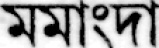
মমাংদা
